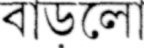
বাড়লো
